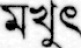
মখুৎ
